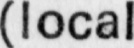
(local
